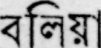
বলিয়া
